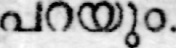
പറയും.
